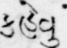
કહેવું
